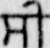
ਸੀ
